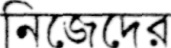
নিজেদের
